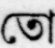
তো
